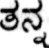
ತನ್ನ
